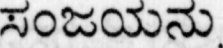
ಸಂಜಯನು
